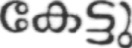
കേട്ടു
